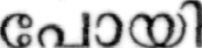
പോയി
